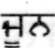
ਜੂਨ
